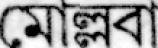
মোল্লবা
